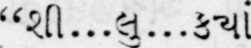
"શી....લુ.....ક્યાં
